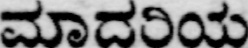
ಮಾದರಿಯ
